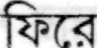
ফিরে
